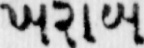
ખરાબ
